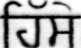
ਹਿੱਸੇ
